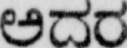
ಅದರ
